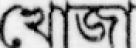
খোজা
